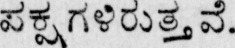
ಪಕ್ಷಗಳಿರುತ್ತವೆ.
